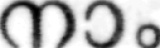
നാം
